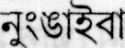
নুংঙাইবা
